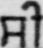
ਸੀ
